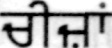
ਚੀਜ਼ਾਂ
